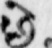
છે.
